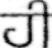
ਹੀ
